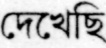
দেখেছি
